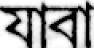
যাবা
